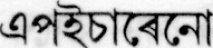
এপইচাৰেনো
